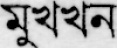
মুখখন
